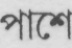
পাশে
